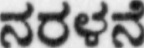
ನರಳನೆ
